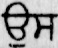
ਉਸ
